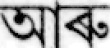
আৰু
